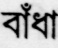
বাঁধা
